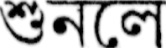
শুনলে
